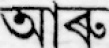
আৰু
